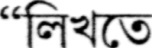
“লিখতে
